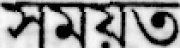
সময়ত
